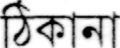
ঠিকানা
